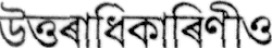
উত্তৰাধিকাৰিণীও
